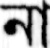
না
